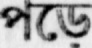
পড়ে
